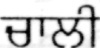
ਚਾਲੀ
